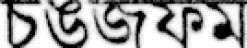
চঙজফম
